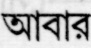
আবার
